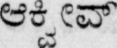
ಆಕ್ವೀವ್
